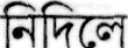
নিদিলে
